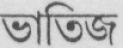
ভাতিজ
